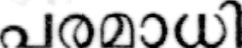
പരമാധി
